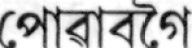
পোৱাবগৈ
